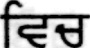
ਵਿਚ
